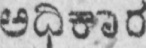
ಅಧಿಕಾರ
